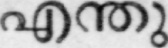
എന്തു
